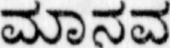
ಮಾನವ
